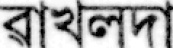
ৱাখলদা
